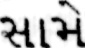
સામે
